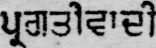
ਪ੍ਰਗਤੀਵਾਦੀ
